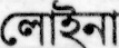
লোইনা
